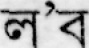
ল'ব
